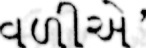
વળીએ'
